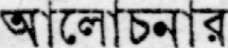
আলোচনার
